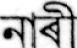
নাৰী
